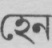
হেন
